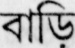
বাড়ি
